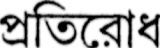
প্রতিরোধ
